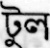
টুল
